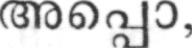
അപ്പൊ,
